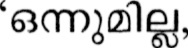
'ഒന്നുമില്ല,
